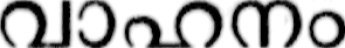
വാഹനം
